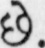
છે.
